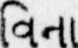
વિના
